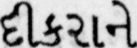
દીકરાને
